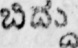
ಬಿದ್ದು
